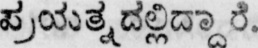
ಪ್ರಯತ್ನದಲ್ಲಿದ್ದಾರೆ.
